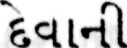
દેવાની
